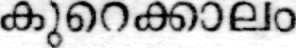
കുറെക്കാലം
